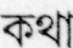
কথা
